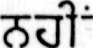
ਨਹੀਂ
